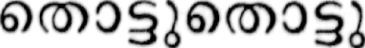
തൊട്ടുതൊട്ടു
